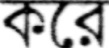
করে
